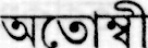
অতোম্বী
